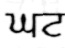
ਘਟ
